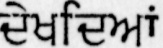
ਦੇਖਦਿਆਂ
